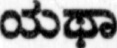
ಯಥಾ
